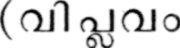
(വിപ്ലവം
